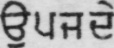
ਉਪਜਦੇ
